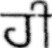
ਹੀ
